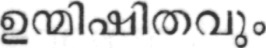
ഉന്മിഷിതവും
